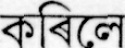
কৰিলে
